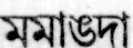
মমাঙদা
